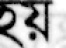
হয়
